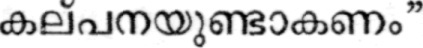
കല്പനയുണ്ടാകണം”
